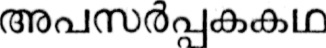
അപസര്‍പ്പകകഥ
